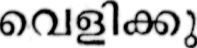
വെളിക്കു
